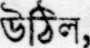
উঠিল,
